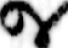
જ
